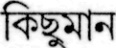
কিছুমান
